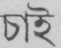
চাই
